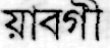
য়াবগী
